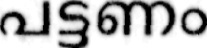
പട്ടണം
